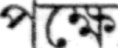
পক্ষে
